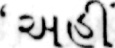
'અહીં
